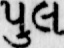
પુલ
